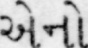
એનો
